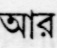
আর
